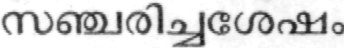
സഞ്ചരിച്ചശേഷം
